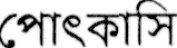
পোৎকাসি
